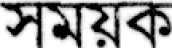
সময়ক
